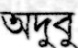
অদুবু
